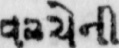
વચ્ચેની
